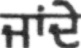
ਜਾਂਦੇ
